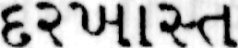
દરખાસ્ત
